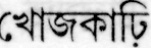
খোজকাঢ়ি
